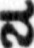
ನ
